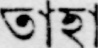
তাহা
